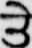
ਤੇ
